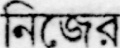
নিজের
